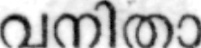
വനിതാ
